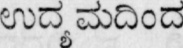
ಉದ್ಯಮದಿಂದ
